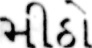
મીઠો
